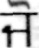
ਜੋ
